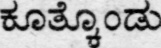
ಕೂತ್ಕೊ೦ಡು
